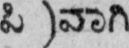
ಪಿ)ವಾಗಿ
